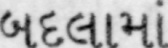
બદલામાં
